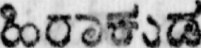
ಹಿರಾಕುಡ
